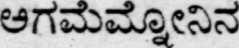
ಅಗಮೆಮ್ನೋನಿನ
